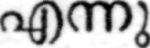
എന്നു
